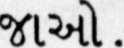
જાઓ.
